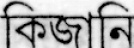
কিজানি
